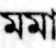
মমা
